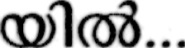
യില്‍…
